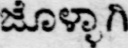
ಜೊಳ್ಳಾಗಿ
